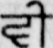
ਵੀ
